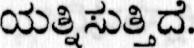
ಯತ್ನಿಸುತ್ತಿದೆ.
